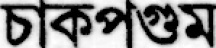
চাকপগুম
